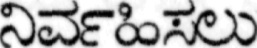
ನಿರ್ವಹಿಸಲು
